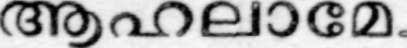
ആഹലാമേ,
